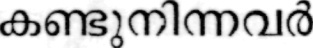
കണ്ടുനിന്നവര്‍
